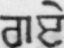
ਗਏ
